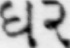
ઘર
